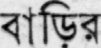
বাড়ির
